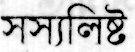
সস্যলিষ্ট
